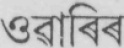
ওৱাৰিৰ
